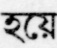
হয়ে
